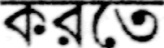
করতে
